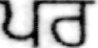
ਪਰ
